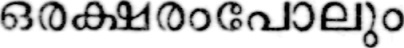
ഒരക്ഷരംപോലും
